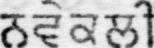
ਨਵੇਕਲੀ
